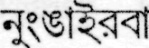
নুংঙাইরবা
